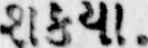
શક્યા.
